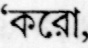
‘করো,
